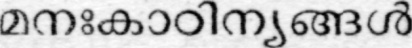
മനഃകാഠിന്യങ്ങള്‍
